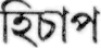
হিচাপ
